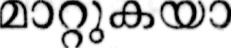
മാറ്റുകയാ
